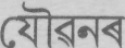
যৌৱনৰ
